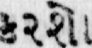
કરશો
